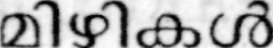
മിഴികള്‍
